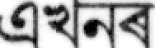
এখনৰ
